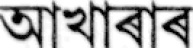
আখাৰাৰ
